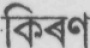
কিৰণ
